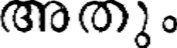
അതും
